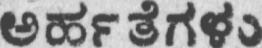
ಅರ್ಹತೆಗಳು
